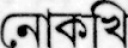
নোকখি
